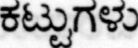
ಕಟ್ಟುಗಳು
